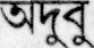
অদুবু
